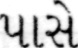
પાસે
